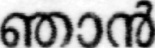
ഞാന്‍
